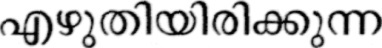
എഴുതിയിരിക്കുന്ന
